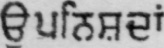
ਉਪਨਿਸ਼ਦਾਂ
